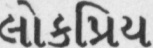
લોકપ્રિય
